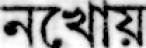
নখোয়
